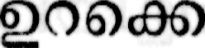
ഉറക്കെ
